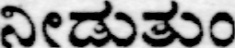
ನೀಡುತುಂ
